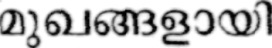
മുഖങ്ങളായി
